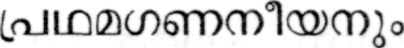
പ്രഥമഗണനീയനും
